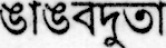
ঙাঙবদুতা
